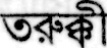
তরুক্কী
